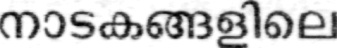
നാടകങ്ങളിലെ
